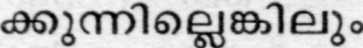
ക്കുന്നില്ലെങ്കിലും
